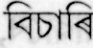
বিচাৰি
